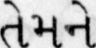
તેમને
